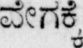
ವೇಗಕ್ಕೆ
